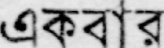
একবার
